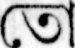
তো
